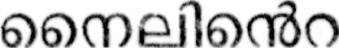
നൈലിന്റെ
